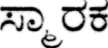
ಸ್ಮಾರಕ
